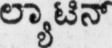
ಲ್ಯಾಟಿನ್
